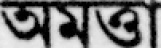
অমত্তা
